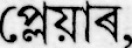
প্লেয়াৰ,
